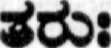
ತರುಃ
